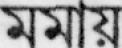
মমায়
